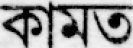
কামত
